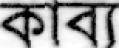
কাব্য
